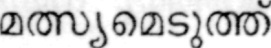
മത്സ്യമെടുത്ത്
